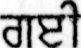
ਗਈ
